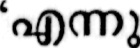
‘എന്നു
